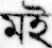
মই
